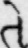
તે
